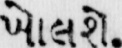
ખોલશે.
